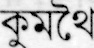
কুমথৈ
